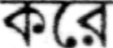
করে
